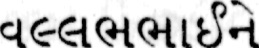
વલ્લભભાઈને
